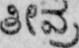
ತೀವ್ರ
